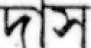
দাস
